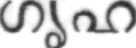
ഗൃഹ
